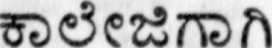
ಕಾಲೇಜಿಗಾಗಿ
